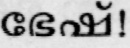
ഭേഷ്!
